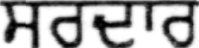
ਸਰਦਾਰ
